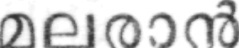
മലരാന്‍
